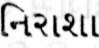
નિરાશા
